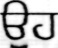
ਉਹ
